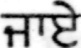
ਜਾਏ
